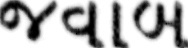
જવાબ
